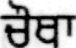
ਚੌਥਾ
